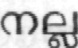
നല്ല
